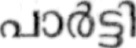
പാര്‍ട്ടി
